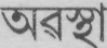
অৱস্থা
